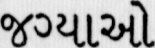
જગ્યાઓ
